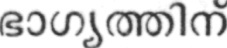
ഭാഗ്യത്തിന്
